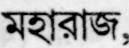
মহারাজ,
